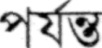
পর্যন্ত
